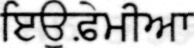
ਇਉਫ਼ੇਮੀਆ
